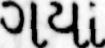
ગયાં
